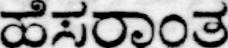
ಹೆಸರಾಂತ
